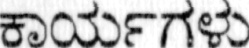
ಕಾರ್ಯಗಳು
